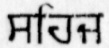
ਸਹਿਜ
